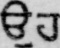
ਉਹ
